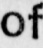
of
